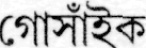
গোসাঁইক
